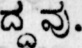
ದ್ದವು.
